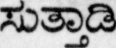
ಸುತ್ತಾಡಿ
